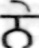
ਨੇ
